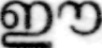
ഈ
